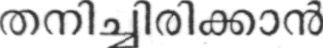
തനിച്ചിരിക്കാന്‍
